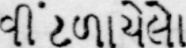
વીંટળાયેલો
